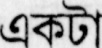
একটা
